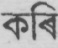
কৰি
